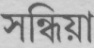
সন্ধিয়া
